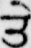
ਤੇ
